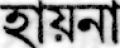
হায়না
